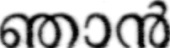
ഞാന്‍
